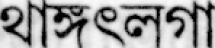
থাঙ্গৎলগা
